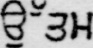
ਉੱਤਮ
